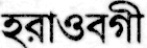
হরাওবগী
